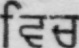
ਵਿਚ
